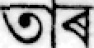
তাৰ
